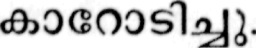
കാറോടിച്ചു.
